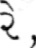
રે,
